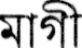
মাগী
